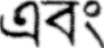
এবং
